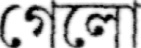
গেলো
